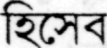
হিসেব
